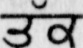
ਤੱਕ
